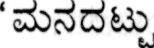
'ಮನದಟ್ಟು
